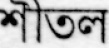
শীতল
